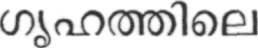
ഗൃഹത്തിലെ
